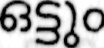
ഒട്ടും
